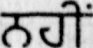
ਨਹੀਂ
